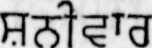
ਸ਼ਨੀਵਾਰ
